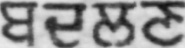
ਬਦਲਣ
